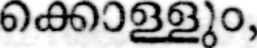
ക്കൊള്ളും,
